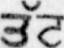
ਤੱਟ
